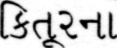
કિતૂરના
